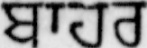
ਬਾਹਰ
